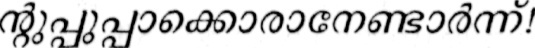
ൻ്റുപ്പുപ്പാക്കൊരാനേണ്ടാർന്ന്!
